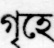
গৃহে
